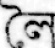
লৈ
